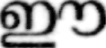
ഈ
